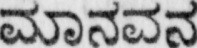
ಮಾನವನ
